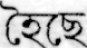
হৈছে
